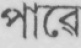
পাৱে
